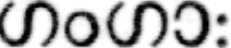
ഗംഗാ:
